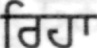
ਰਿਹਾ
